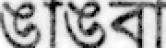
ঙাঙবা
